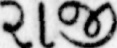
રાજી
